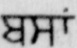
ਬਸਾਂ
